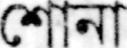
শোনা
